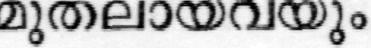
മുതലായവയും
